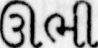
ઊભી
